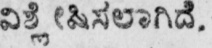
ವಿಶ್ಲೇಷಿಸಲಾಗಿದೆ.
